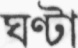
ঘণ্টা
